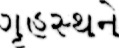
ગૃહસ્થને
